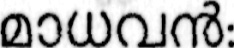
മാധവന്‍:
